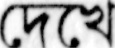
দেখে
